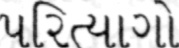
પરિત્યાગો
